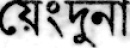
য়েংদুনা
